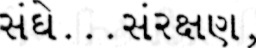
સંઘે...સંરક્ષણ,
